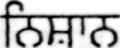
ਨਿਸ਼ਾਨ
